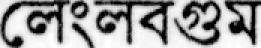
লেংলবগুম
